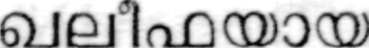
ഖലീഫയായ
